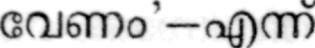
വേണം’-എന്ന്
